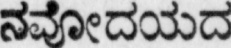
ನವೋದಯದ
